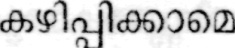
കഴിപ്പിക്കാമെ
